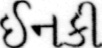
ઈનકી
